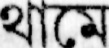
থামে
